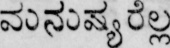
ಮನುಷ್ಯರೆಲ್ಲ
